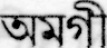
অমগী
